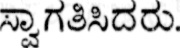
ಸ್ವಾಗತಿಸಿದರು.
